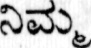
ನಿಮ್ಮ
